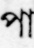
পা
